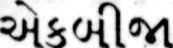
એકબીજા
